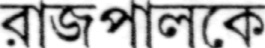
রাজপালকে
